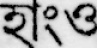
হাংও
